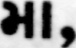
મા,
